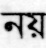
নয়
